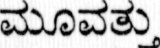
ಮೂವತ್ತು
